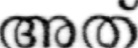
അത്
